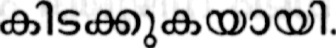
കിടക്കുകയായി.
